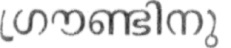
ഗ്രൌണ്ടിനു
